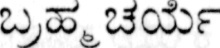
ಬ್ರಹ್ಮಚರ್ಯೆ
